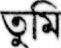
তুমি
